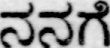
ನನಗೆ
